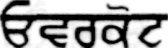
ਓਵਰਕੋਟ
